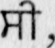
ਸੀ,
